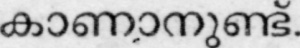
കാണാനുണ്ട്.
